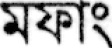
মফাং
